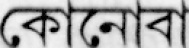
কোনোবা
